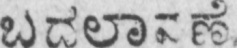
ಬದಲಾವಣೆ
